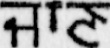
ਜਾਣ
